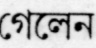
গেলেন
